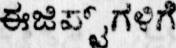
ಈಜಿಪ್ಟ್‌ಗಳಿಗೆ
